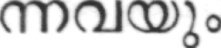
ന്നവയും
